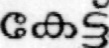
കേട്ട്
